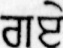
ਗਏ
